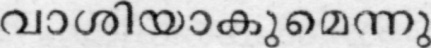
വാശിയാകുമെന്നു
